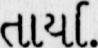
તાર્યા.
